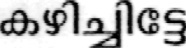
കഴിച്ചിട്ടേ
